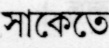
সাকেতে
